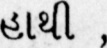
હાથી,
